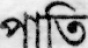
পাতি
